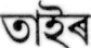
তাইৰ
